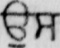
ਉਸ
